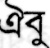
ঐবু
